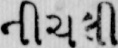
નીચલી
